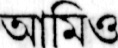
আমিও
